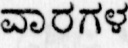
ವಾರಗಳ
